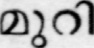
മുറി
